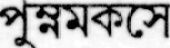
পুম্নমকসে
